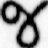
જ
